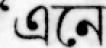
'এনে
